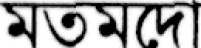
মতমদো
